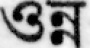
ওন্ন
